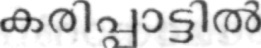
കരിപ്പാട്ടില്‍
